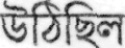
উঠিছিল
